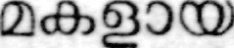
മകളായ
